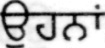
ਉਹਨਾਂ
